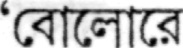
‘বোলোরে
